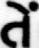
તેં
